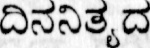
ದಿನನಿತ್ಯದ
